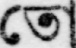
তো
